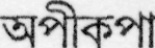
অপীকপা
